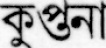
কুপ্তনা
